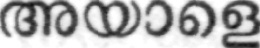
അയാളെ
